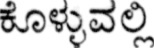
ಕೊಳ್ಳುವಲ್ಲಿ
